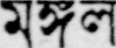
মঙ্গল
